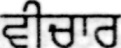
ਵੀਚਾਰ
